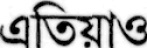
এতিয়াও
